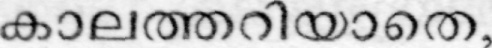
കാലത്തറിയാതെ,
